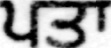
ਪਤਾ
